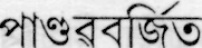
পাণ্ডৱবর্জিত
